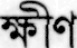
ক্ষীণ
